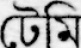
টেমি
